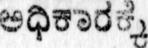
ಅಧಿಕಾರಕ್ಕೆ
